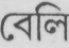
বেলি
